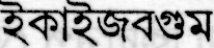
ইকাইজবগুম
